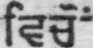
ਵਿਚੋਂ
